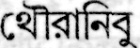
থৌরানিবু
